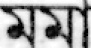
মমা
